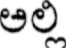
ಅಲ್ಲಿ
